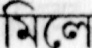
মিলে
